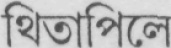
থিতাপিলে
